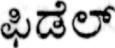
ಫಿಡೆಲ್
